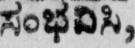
ಸಂಭವಿಸಿ,
